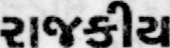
રાજકીય
